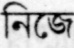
নিজে
